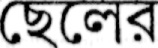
ছেলের
